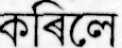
কৰিলে
